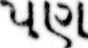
પણ
